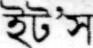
ইট'স
